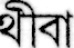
থীবা
